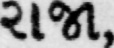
રાજા,
